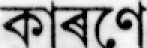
কাৰণে
